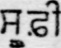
ਸੂਫ਼ੀ
